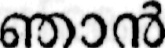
ഞാന്‍
